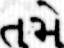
તમે
